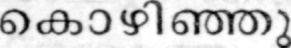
കൊഴിഞ്ഞു
